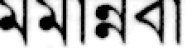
মমান্নবা
